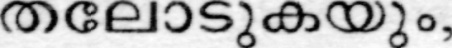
തലോടുകയും,
